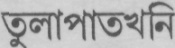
তুলাপাতখনি
